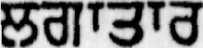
ਲਗਾਤਾਰ
